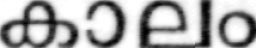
കാലം
